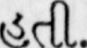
હતી.
